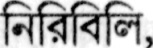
নিরিবিলি,
